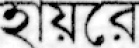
হায়রে
